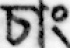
চাং
